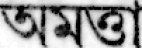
অমত্তা
